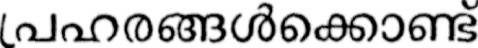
പ്രഹരങ്ങള്‍ക്കൊണ്ട്
